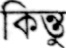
কিন্ত
